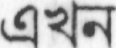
এখন
